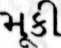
મૂકી
